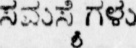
ಸಮಸ್ಯೆಗಳು
